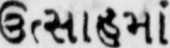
ઉત્સાહમાં
